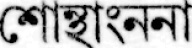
শোন্থাংননা
